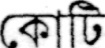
কোটি
